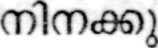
നിനക്കു
